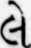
લે
